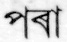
পৰা
